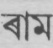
ৰাম
